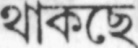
থাকছে
